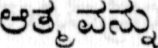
ಆತ್ಮವನ್ನು
